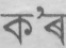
ক'ৰ
